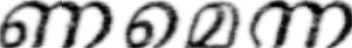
ണമെന്ന
